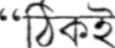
“ঠিকই
